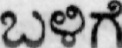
ಬಳಿಗೆ
